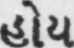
હોય
